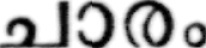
ചാരം
